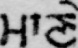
ਮਾਣੇ
